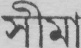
সীমা
